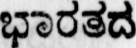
ಭಾರತದ
